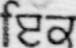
ਇਕ
